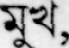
মুখ,
